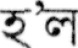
হ'ল
